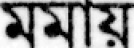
মমায়
